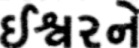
ઈશ્વરે
